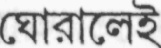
ঘোরালেই
